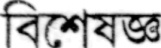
বিশেষজ্ঞ
